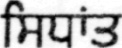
ਸਿਧਾਂਤ
